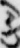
કે
